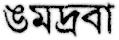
ঙমদ্রবা
